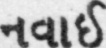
નવાઈ
